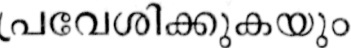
പ്രവേശിക്കുകയും
